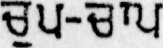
ਚੁਪ-ਚਾਪ
